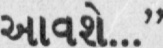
આવશે..."
